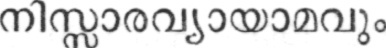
നിസ്സാരവ്യായാമവും
